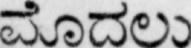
ಮೊದಲು
